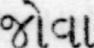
જોવા
